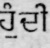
ਹੁੰਦੀ
